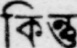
কিন্তু
